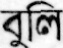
বুলি
